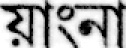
য়াংনা
